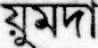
য়ুমদা
